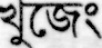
খুজেং
